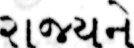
રાજ્યને
